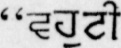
''ਵਹੁਟੀ
